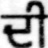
ਦੀ
